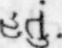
હતું.
